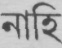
নাহি
